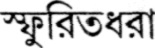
স্ফুরিতধরা
